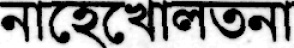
নাহেখোলতনা
